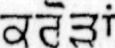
ਕਰੋੜਾਂ
